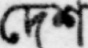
দেশ
